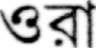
ওরা
